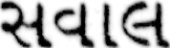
સવાલ
